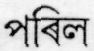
পৰিল
